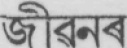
জীৱনৰ
